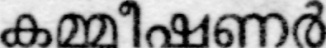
കമ്മീഷണര്‍
